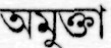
অমুক্তা
